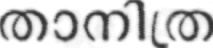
താനിത്ര
